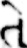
તે
